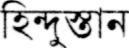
হিন্দুস্তান
